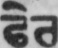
ਫੇਰ
